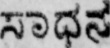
ಸಾಧನ
